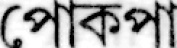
পোকপা
